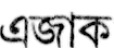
এজাক
